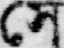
সে
